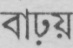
বাঢ়য়
